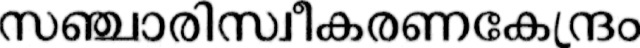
സഞ്ചാരിസ്വീകരണകേന്ദ്രം
